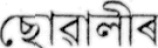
ছোৱালীৰ
